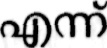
എന്ന്
